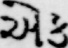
એક
